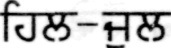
ਹਿਲ-ਜੁਲ
